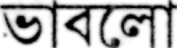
ভাবলো
